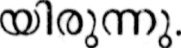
യിരുന്നു.
